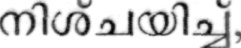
നിശ്ചയിച്ച്,
